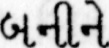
બનીને
